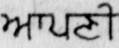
ਆਪਣੀ
